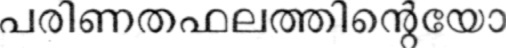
പരിണതഫലത്തിന്റെയോ
